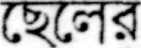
ছেলের
